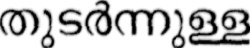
തുടര്‍ന്നുള്ള
